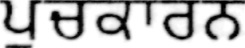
ਪੁਚਕਾਰਨ
